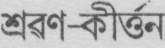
শ্ৰৱণ-কীৰ্ত্তন
